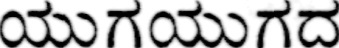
ಯುಗಯುಗದ
